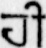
ਹੀ
